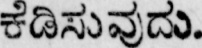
ಕೆಡಿಸುವುದು.
